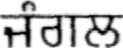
ਜੰਗਲ
